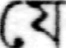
যে
